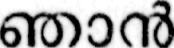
ഞാന്‍
